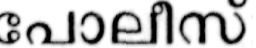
പോലീസ്
